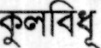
কুলবিধূ
